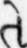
તે
